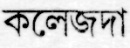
কলেজদা
